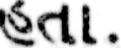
હતા.
